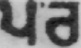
ਪਰ
